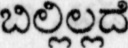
ಬಿಲ್ಲಿಲ್ಲದೆ
